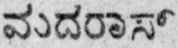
ಮದರಾಸ್
